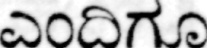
ಎಂದಿಗೂ
